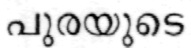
പുരയുടെ
